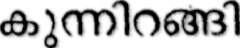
കുന്നിറങ്ങി
